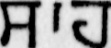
ਸਾਹ
